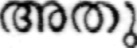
അതു
